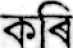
কৰি
